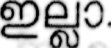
ഇല്ലാ.
